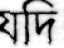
যদি
